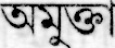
অমুক্তা
